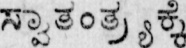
ಸ್ವಾತಂತ್ರ್ಯಕ್ಕೆ
